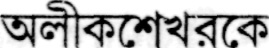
অলীকশেখরকে
